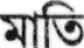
মাতি
